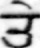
ਤੇ
